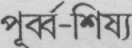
পূৰ্ব্ব-শিষ্য
